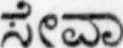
ಸೇವಾ
